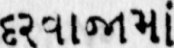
દરવાજામાં
